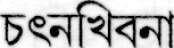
চৎনখিবনা
